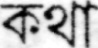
কথা
